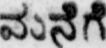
ಮನೆಗೆ
